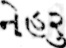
નેહરુ
